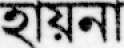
হায়না
